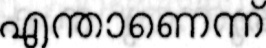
എന്താണെന്ന്
